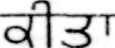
ਕੀਤਾ
